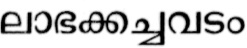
ലാഭക്കച്ചവടം
